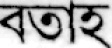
বতাহ
